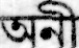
অনী
